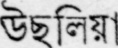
উছলিয়া
